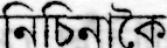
নিচিনাকৈ
